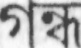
গন্ধ
